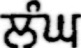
ਲੰਘ
